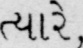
ત્યારે,
